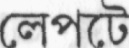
লেপটে
